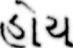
હોય
